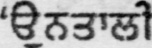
'ਉਨਤਾਲੀ
